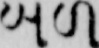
બળ
